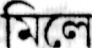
মিলে
